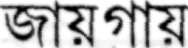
জায়গায়
